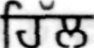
ਹਿੱਲ
